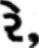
રે,
